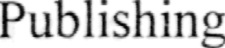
Publishing
